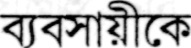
ব্যবসায়ীকে
